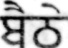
ਬੈਠੇ
